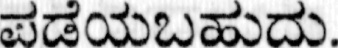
ಪಡೆಯಬಹುದು.
